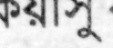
কয়াসু
